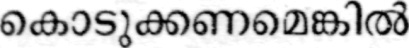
കൊടുക്കണമെങ്കില്‍
